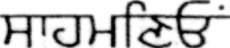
ਸਾਹਮਣਿਓਂ
